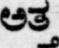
ಅತ್ತ
